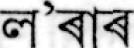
ল'ৰাৰ
